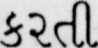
કરતી
